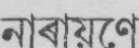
নাৰায়ণে
